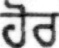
ਹੋਰ
